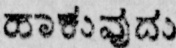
ಹಾಕುವುದು
